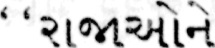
"રાજાઓને
